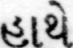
હાથે
